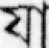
যা
